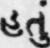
હતું
